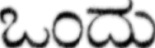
ಒಂದು
